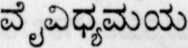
ವೈವಿಧ್ಯಮಯ
